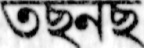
তছনছ
